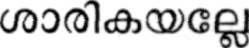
ശാരികയല്ലേ
